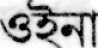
ওইনা
